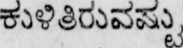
ಕುಳಿತಿರುವಷ್ಟು
